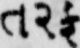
તરફ
